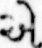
એ
